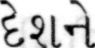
દેશને
